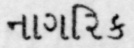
નાગરિક
